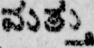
ಮತ್ತು
